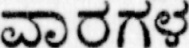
ವಾರಗಳ
